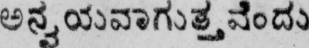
ಅನ್ವಯವಾಗುತ್ತವೆಂದು
